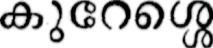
കുറേശ്ശെ
